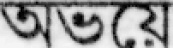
অভয়ে
